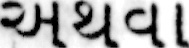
અથવા
